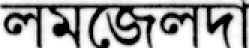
লমজেলদা
